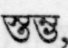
স্তম্ভ,
